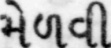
મેળવી
